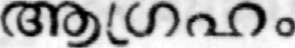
ആഗ്രഹം
